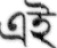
এই
